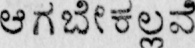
ಆಗಬೇಕಲ್ಲವೆ
